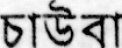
চাউবা
